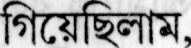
গিয়েছিলাম,
